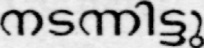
നടന്നിട്ടു
